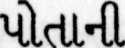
પોતાની
